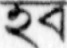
হব
